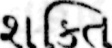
શક્તિ
